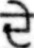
ਦੇ
